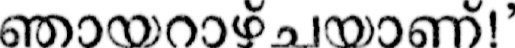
ഞായറാഴ്ചയാണ്!’
